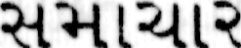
સમાચાર
